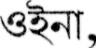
ওইনা,
